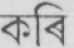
কৰি
